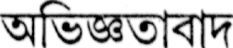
অভিজ্ঞতাবাদ
